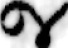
જ
